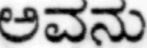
ಅವನು
